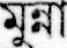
মুন্না
